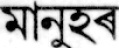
মানুহৰ
